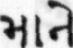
માને
